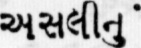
અસલીનું
